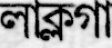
লাক্লগা
